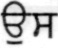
ਉਸ
